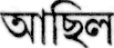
আছিল
